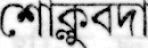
শোক্লুবদা
